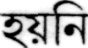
হয়নি
